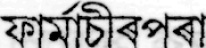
ফাৰ্মাচীৰপৰা
